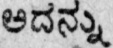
ಅದನ್ನು
